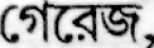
গেরেজ,
